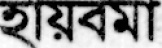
হায়বমা
